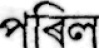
পৰিল
